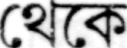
থেকে
